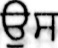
ਉਸ
